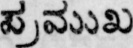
ಪ್ರಮುಖ
